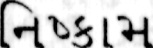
નિષ્કામ
